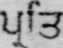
ਪ੍ਰਤਿ
